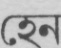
হেন
